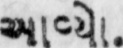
આવ્યો.
